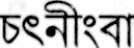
চৎনীংবা
